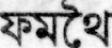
ফমথৈ
